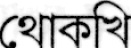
থোকখি
